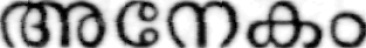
അനേകം
